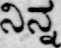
ನಿನ್ನ
